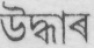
উদ্ধাৰ
